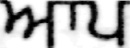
ਆਪ
